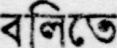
বলিতে
